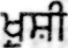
ਖੁਸ਼ੀ
